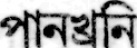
পানখ্রনি
